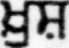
ਖ਼ੁਸ਼
